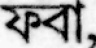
ফবা,
